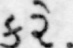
કરે.
